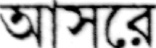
আসরে
